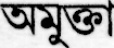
অমুক্তা
